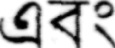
এবং
